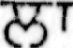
ਲਾ
